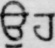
ਉਹ
